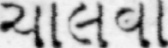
ચાલવા
